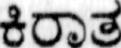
ಕಿರಾತ
